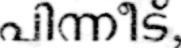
പിന്നീട്,
